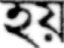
হয়
